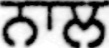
ਨਾਲ
